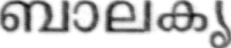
ബാലകൃ
